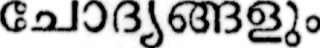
ചോദ്യങ്ങളും
